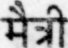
मैत्री
